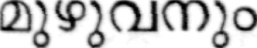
മുഴുവനും
